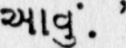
આવું.'
